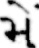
મેં
